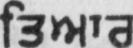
ਤਿਆਰ
